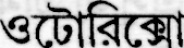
ওটোরিক্সো
